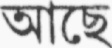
আছে
